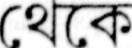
থেকে
